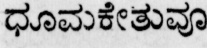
ಧೂಮಕೇತುವೂ
